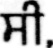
ਸੀ,
